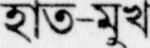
হাত-মুখ
